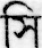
সি
